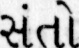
સંતો
